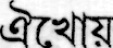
ঐখোয়
